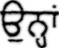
ਉਨ੍ਹਾਂ
